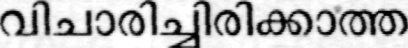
വിചാരിച്ചിരിക്കാത്ത
